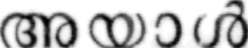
അയാള്‍
